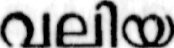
വലിയ
